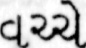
વચ્ચે
